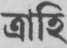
ত্ৰাহি
